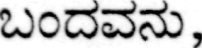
ಬಂದವನು,
